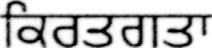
ਕਿਰਤਗਤਾ
